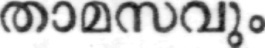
താമസവും
